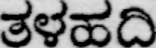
ತಳಹದಿ
